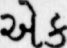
એક
